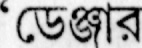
‘ডেঞ্জার
